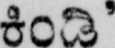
ಕಿಂಡಿ’
